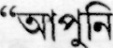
"আপুনি
